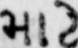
માટે
